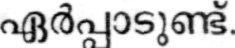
ഏര്‍പ്പാടുണ്ട്.
